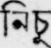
নিচু
